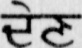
ਦੇਣ
